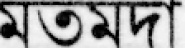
মতমদা
